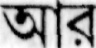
আর
